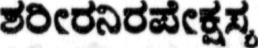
ಶರೀರನಿರಪೇಕ್ಷಸ್ಯ
